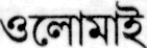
ওলোমাই
